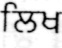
ਲਿਖ
